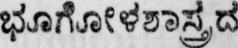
ಭೂಗೋಳಶಾಸ್ತ್ರದ
